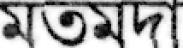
মতমদা
